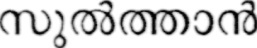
സുല്‍ത്താന്‍
